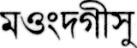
মওংদগীসু
